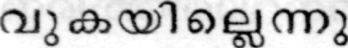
വുകയില്ലെന്നു
